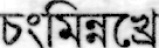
চংমিন্নখ্রে
